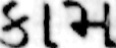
કામ
